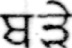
ਬੜੇ
